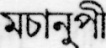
মচানুপী
